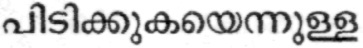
പിടിക്കുകയെന്നുള്ള
